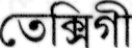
তেক্সিগী
